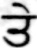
ਤੇ
